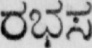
ರಭಸ
